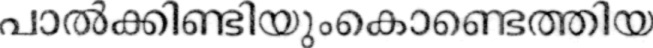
പാല്‍ക്കിണ്ടിയുംകൊണ്ടെത്തിയ
